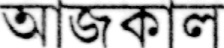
আজকাল
